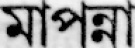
মাপন্না
